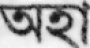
অহা
